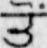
ਤੋਂ
